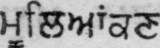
ਮੂਲਿਆਂਕਣ
